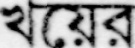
খয়ের
